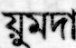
য়ুমদা
